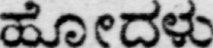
ಹೋದಳು
